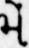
મેં
